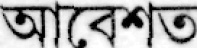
আবেশত
